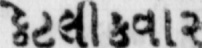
કેટલીકવાર
